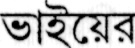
ভাইয়ের
